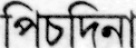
পিচদিনা
